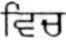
ਵਿਚ
